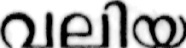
വലിയ
